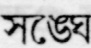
সঙ্ঘে
